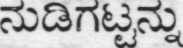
ನುಡಿಗಟ್ಟನ್ನು
